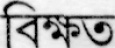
বিক্ষত
